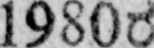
1980ರ
